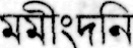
মমীংদনি
